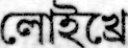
লোইখ্রে
